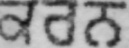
ਕਰਨ
